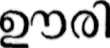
ഊരി
